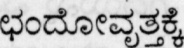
ಛಂದೋವೃತ್ತಕ್ಕೆ
